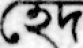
হেদ
